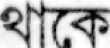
থাকে
